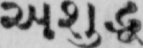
અશુદ્ધ
